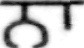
ਨਾ
